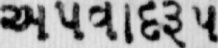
અપવાદરૂપ
